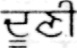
ਦੂਣੀ
